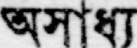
অসাধ্য
